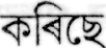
কৰিছে
